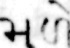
મળે
